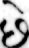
છે
